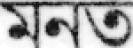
মনত
